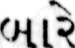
બારે
